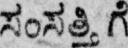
ಸಂಸತ್ತಿಗೆ
